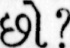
છો?
